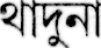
থাদুনা
